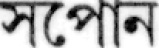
সপোন
